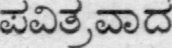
ಪವಿತ್ರವಾದ
